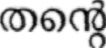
തന്റെ
